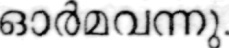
ഓര്‍മവന്നു.
